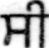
ਸੀ
